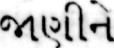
જાણીને
